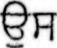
ਉਸ
